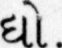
દ્યો.
